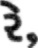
રે,
